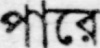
পারে
